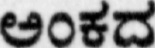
ಅಂಕದ
